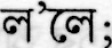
ল'লে;
